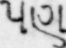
પણ
